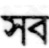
সব
